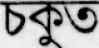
চকুত
